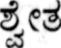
ಶ್ವೇತ
